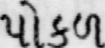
પોકળ
